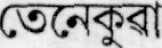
তেনেকুৱা
